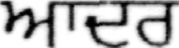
ਆਦਰ
